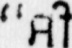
''ਸੀ
